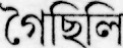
গৈছিলি
